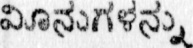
ಮೀನುಗಳನ್ನು
